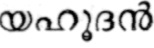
യഹൂദന്‍
